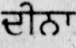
ਦੀਨਾ
